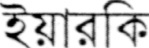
ইয়ারকি
